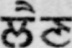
ਲੈਣ
